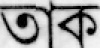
তাক
